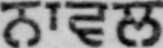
ਨਾਵਲ
